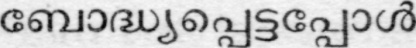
ബോദ്ധ്യപ്പെട്ടപ്പോള്‍
